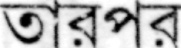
তারপর
